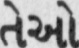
તેઓ
